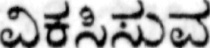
ವಿಕಸಿಸುವ
